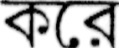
করে
